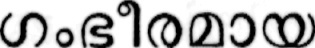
ഗംഭീരമായ
